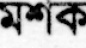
মশক
